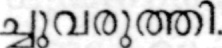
ച്ചുവരുത്തി.
